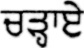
ਚੜ੍ਹਾਏ
